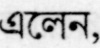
এলেন,
